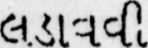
લડાવવી
